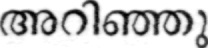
അറിഞ്ഞു
